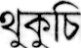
থুকুচি
